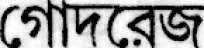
গোদরেজ
